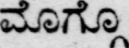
ಮೊಗ್ಗೊ
